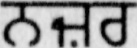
ਨਜ਼ਰ
